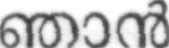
ഞാന്‍
